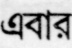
এবার
